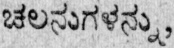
ಚಲನುಗಳನ್ನು,
